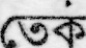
তেক
